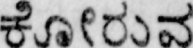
ಕೋರುವ
